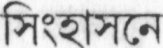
সিংহাসনে
